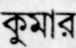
কুমার
